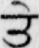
ਤੇ
